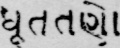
ધૃતતણો
